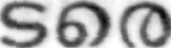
ടരെ
